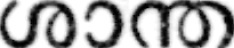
ശാന്ത
